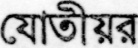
যোতীয়র
